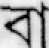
বা
